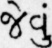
જેવું
